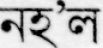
নহ'ল
